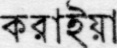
করাইয়া
